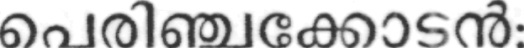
പെരിഞ്ചക്കോടന്‍:
